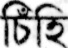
চিঁহি
